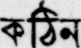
কঠিন
